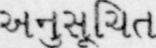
અનુસૂચિત
